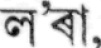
ল'ৰা,
